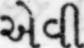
એવી
